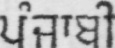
ਪੰਜਾਬੀ
